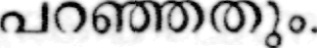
പറഞ്ഞതും.
